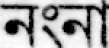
নংনা
